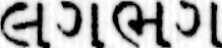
લગભગ
